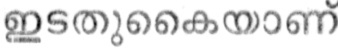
ഇടതുകൈയാണ്
